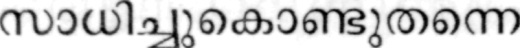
സാധിച്ചുകൊണ്ടുതന്നെ
